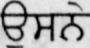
ਉਸਨੇ
